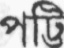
পট্টি
